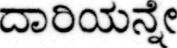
ದಾರಿಯನ್ನೇ
